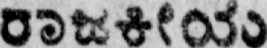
ರಾಜಕೀಯ
